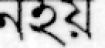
নহয়
